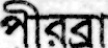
পীরব্রা
